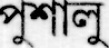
পুশালু
